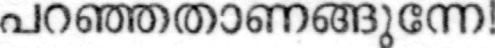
പറഞ്ഞതാണങ്ങുന്നേ!
